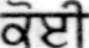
ਕੋਈ
